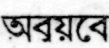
অবয়বে
